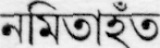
নমিতাহঁত
